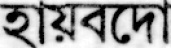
হায়বদো
